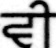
ਵੀ
